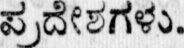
ಪ್ರದೇಶಗಳು.
